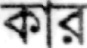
কার
